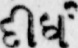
દીર્ઘ
